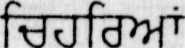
ਚਿਹਰਿਆਂ
